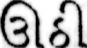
ઊઠી
